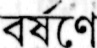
বর্ষণে
